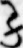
કે
